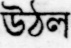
উঠল
